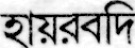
হায়রবদি
